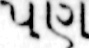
પણ
